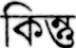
কিন্তু
